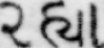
રહ્યા
